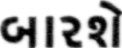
બારશે
